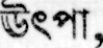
ঊৎপা,
